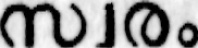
സ്വരം
